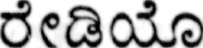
ರೇಡಿಯೊ
